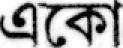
একো
